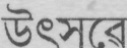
উৎসৱে
